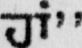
ਹਾਂ''
